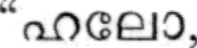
“ഹലോ,
